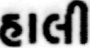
હાલી
